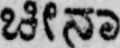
ಚೀನಾ
